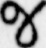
જ
